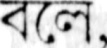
বলে,
